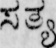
ಸತ್ಯ
